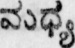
ಮಧ್ಯ
